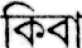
কিবা
